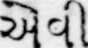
એવી
